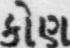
કોણ
